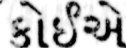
કોઈએ
